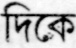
দিকে
